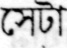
সেটা
